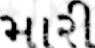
મારી
